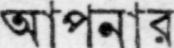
আপনার
